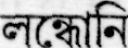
লন্ধোনি
